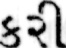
કરી
